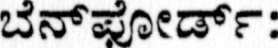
ಬೆನ್‌ಫೋರ್ಡ್:
